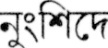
নুংশিদে
